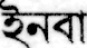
ইনবা
